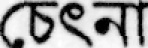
চেৎনা
